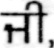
ਜੀ,
